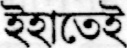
ইহাতেই
